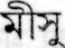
মীসু
